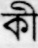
কী
